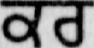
ਕਰ
